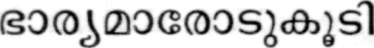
ഭാര്യമാരോടുകൂടി
